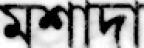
মশাদা
